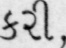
કરી,
